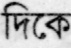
দিকে
